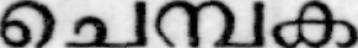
ചെമ്പക
